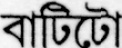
বাটিটো
